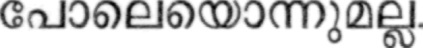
പോലെയൊന്നുമല്ല.
